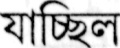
যাচ্ছিল
